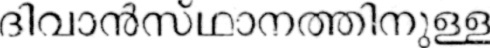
ദിവാന്‍സ്ഥാനത്തിനുള്ള
